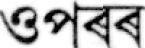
ওপৰৰ
